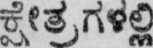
ಕ್ಷೇತ್ರಗಳಲ್ಲಿ
